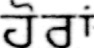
ਹੋਰਾਂ
